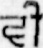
ਵੀ
